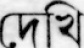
দেখি
